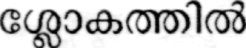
ശ്ലോകത്തില്‍
